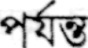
পর্যন্ত
